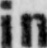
in
